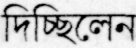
দিচ্ছিলেন
